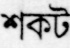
শকট
